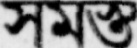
সমস্ত
